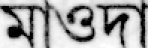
মাওদা
